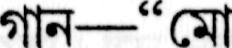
গান--"মো
